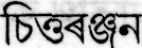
চিত্তৰঞ্জন
